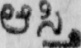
ಆಸ್ತಿ
